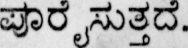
ಪೂರೈಸುತ್ತದೆ.
